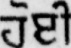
ਹੋਈ
